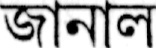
জানাল
